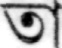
তা
